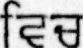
ਵਿਚ
